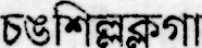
চঙশিল্লক্লগা
